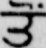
ਤੋਂ
